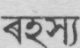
ৰহস্য
